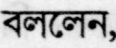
বললেন,
